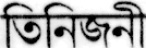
তিনিজনী
